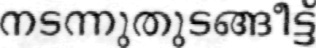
നടന്നുതുടങ്ങീട്ട്
